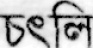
চৎলি
